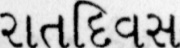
રાતદિવસ
